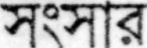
সংসার
